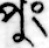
পুং
